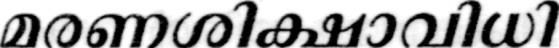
മരണശിക്ഷാവിധി
